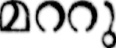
മററു
